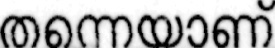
തന്നെയാണ്
